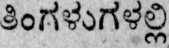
ತಿಂಗಳುಗಳಲ್ಲಿ
